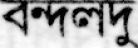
বন্দলদু
